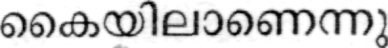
കൈയിലാണെന്നു
